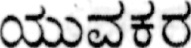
ಯುವಕರ
